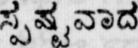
ಸ್ಪಷ್ಟವಾದ
